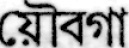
য়ৌবগা
